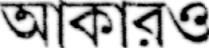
আকারও
